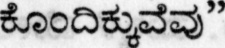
ಕೊಂದಿಕ್ಕುವೆವು"
